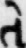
તે
